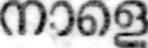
നാളെ
